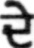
ਦੇ
